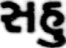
સહુ
